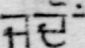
ਜਦੋਂ
